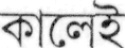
কালেই
